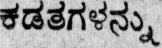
ಕಡತಗಳನ್ನು
